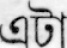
এটা
